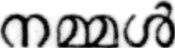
നമ്മള്‍
